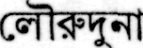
লৌরুদুনা
